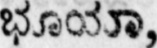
ಭೂಯಾ,
